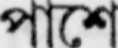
পাশে
